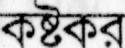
কষ্টকর
